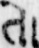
તો
